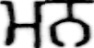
ਮਨ
